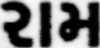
રામ
